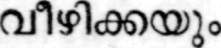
വീഴിക്കയും
